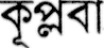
কুপ্লবা
